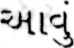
આવું
